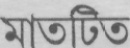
মাতটিত
